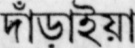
দাঁড়াইয়া
